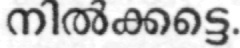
നില്‍ക്കട്ടെ.
